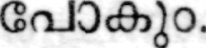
പോകും.
